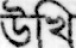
উখি
